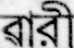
ৱারী
